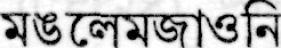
মঙলেমজাওনি
